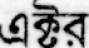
এক্টর
